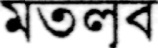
মতলব
